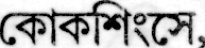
কোকশিংসে,
